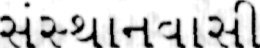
સંસ્થાનવાસી
